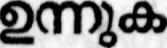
ഉന്നുക
